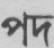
পদ
